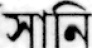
সানি
